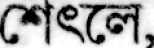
শেৎলে,
